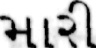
મારી
